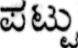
ಪಟ್ಟು
